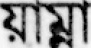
য়াম্না
